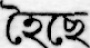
হৈছে
